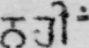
ਨਹੀਂ
